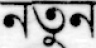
নতুন
